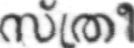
സ്ത്രീ
